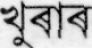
খুৰাৰ
